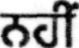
ਨਹੀਂ
